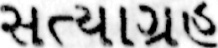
સત્યાગ્રહ
